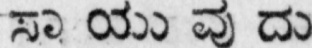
ಸಾಯುವುದು
